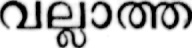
വല്ലാത്ത
